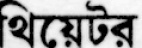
থিয়েটর
